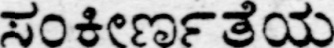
ಸಂಕೀರ್ಣತೆಯ
